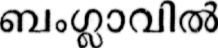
ബംഗ്ലാവില്‍
